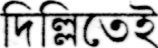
দিল্লিতেই
